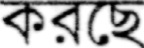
করছে
